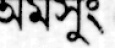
অমসুং
